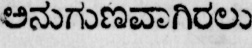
ಅನುಗುಣವಾಗಿರಲು
